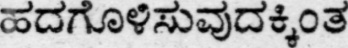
ಹದಗೊಳಿಸುವುದಕ್ಕಿಂತ
